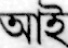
আই
